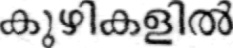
കുഴികളില്‍
